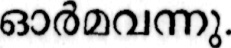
ഓര്‍മവന്നു.
